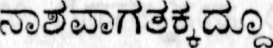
ನಾಶವಾಗತಕ್ಕದ್ದೂ
